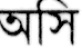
অসি
